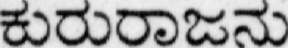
ಕುರುರಾಜನು
